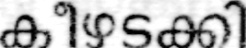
കീഴടക്കി
